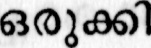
ഒരുക്കി
